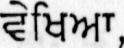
ਵੇਖਿਆ,
